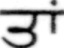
ਤਾਂ
